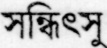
সন্ধিত্সু
